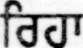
ਰਿਹਾ
